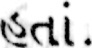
હતાં.
